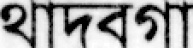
থাদবগা
